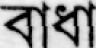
বাধা
